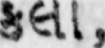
કલા,
